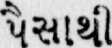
પૈસાથી
